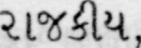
રાજકીય,
